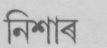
নিশাৰ
